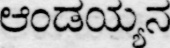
ಆಂಡಯ್ಯನ
